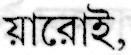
য়ারোই,
